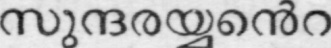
സുന്ദരയ്യന്റെ
